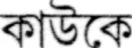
কাউকে
